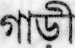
গাড়ী
